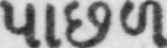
પાછળ
